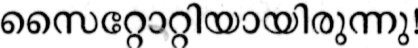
സൈറ്റോറ്റിയായിരുന്നു!
